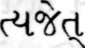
ત્યજેત્
